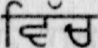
ਵਿੱਚ
